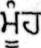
ਮੂੰਹ
